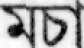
মচা
